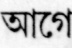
আগে
